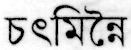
চৎমিন্নৈ
